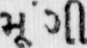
મૂંગી
